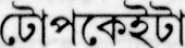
টোপকেইটা
